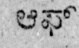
ಆಫ್
